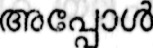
അപ്പോള്‍
